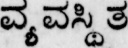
ವ್ಯವಸ್ಥಿತ
